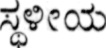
ಸ್ಥಳೀಯ
